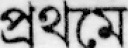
প্রথমে
